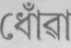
ধোঁৱা
